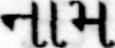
નામ
